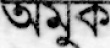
অমুক
